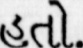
હતો.
